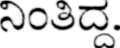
ನಿಂತಿದ್ದ.
